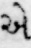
એ
